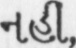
નહીં,
